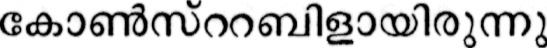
കോണ്‍സ്റ്റബിളായിരുന്നു
